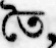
তৈ,
